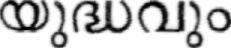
യുദ്ധവും
